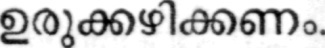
ഉരുക്കഴിക്കണം.
